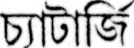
চ্যাটার্জি
